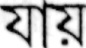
যায়
